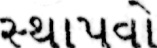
સ્થાપવો
